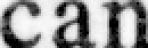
can
